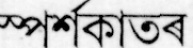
স্পর্শকাতৰ
